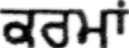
ਕਰਮਾਂ
